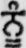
ਨੂੰ
